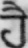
ਹੈ
